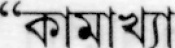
"কামাখ্যা
